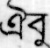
ঐবু
